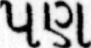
પણ
